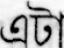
এটা
